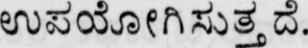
ಉಪಯೋಗಿಸುತ್ತದೆ.
